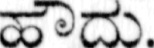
ಹೌದು.
